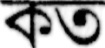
কত
